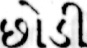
છોડી
